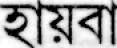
হায়বা
